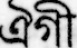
ঐগী
